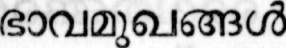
ഭാവമുഖങ്ങള്‍
